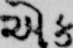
એક
